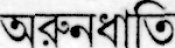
অরুনধাতি
